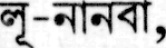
লূ-নানবা,
